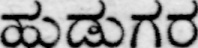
ಹುಡುಗರ
